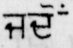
ਜਦੋਂ
